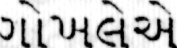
ગોખલેએ
